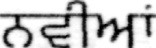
ਨਵੀਆਂ
